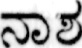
ನಾಶ
